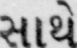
સાથે
